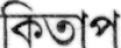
কিতাপ
